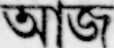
আজ
